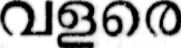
വളരെ
